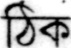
ঠিক
